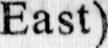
East)
